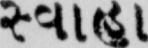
સ્વાહા
